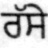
ਰੱਸੇ
